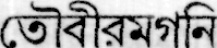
তৌবীরমগনি
